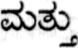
ಮತ್ತು
